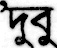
’দুবু
